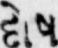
દોષ
